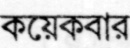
কয়েকবার
